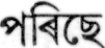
পৰিছে
